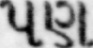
પણ
